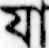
যা
